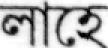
লাহে
